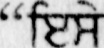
''ਇਸੇ
